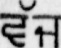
ਵੱਜ
